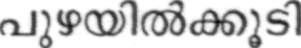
പുഴയില്‍ക്കൂടി
